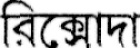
রিক্সোদা
